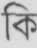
কি
